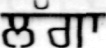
ਲੱਗਾ
